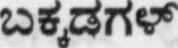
ಬಕ್ಕಡಗಳ್
